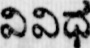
ವಿವಿಧ
